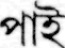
পাই
